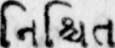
નિશ્ચિત
